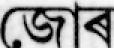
জোৰ
